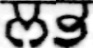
ਲਭ
